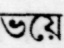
ভয়ে
